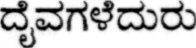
ದೈವಗಳೆದುರು
